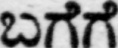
ಬಗೆಗೆ
